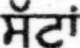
ਸੱਟਾਂ
